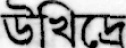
উখিদ্রে
